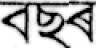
বছৰ
